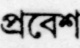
প্রবেশ
